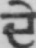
ਦੇ
